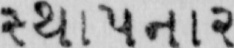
સ્થાપનાર
